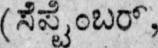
(ಸೆಪ್ಟೆಂಬರ್,
